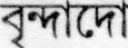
বৃন্দাদো
